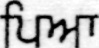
ਪਿਆ
